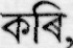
কৰি,
